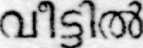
വീട്ടില്‍
